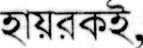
হায়রকই,
